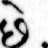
છે.
